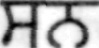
ਸਨ
